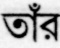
তাঁর
